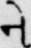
ને
